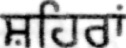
ਸ਼ਹਿਰਾਂ
